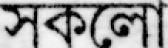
সকলো
